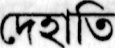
দেহাতি
